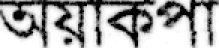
অয়াকপা
